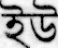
ইউ
